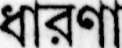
ধারণা
